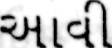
આવી
